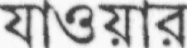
যাওয়ার
